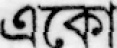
একো
